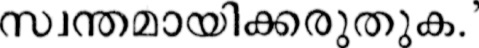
സ്വന്തമായിക്കരുതുക.’
